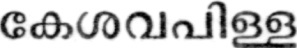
കേശവപിള്ള
